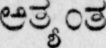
ಅತ್ಯಂತ
